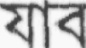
যাব
